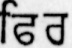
ਫਿਰ
